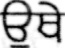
ਉਥੇ
